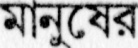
মানুষের
